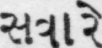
સવારે
